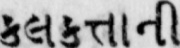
કલકત્તાની
